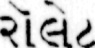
રૉલેટ
